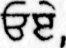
ਓਏ,
